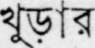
খুড়ার
